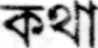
কথা
